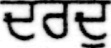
ਦਰਦੁ
